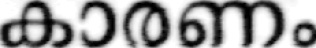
കാരണം
